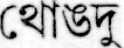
থোঙদু
